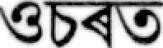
ওচৰত
